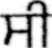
ਸੀ
